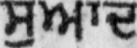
ਸੁਆਦ
